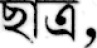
ছাত্র,
